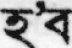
হ'ব
